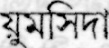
য়ুমসিদা
